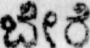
ಬೇರೆ
